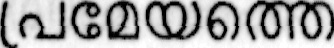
പ്രമേയത്തെ
